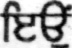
ਇਉਂ
